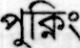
পুক্নিং
